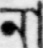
না
